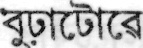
বুঢ়াটোৱে
